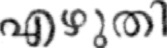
എഴുതി
